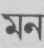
মন
